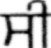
ਸੀ
